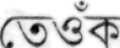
তেওঁক
